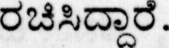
ರಚಿಸಿದ್ದಾರೆ.
